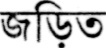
জড়িত
